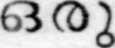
ഒരു
